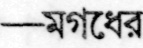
–মগধের
